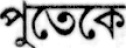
পুতেকে
